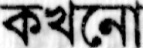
কখনো
